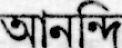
আনন্দি
